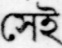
সেই
